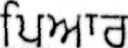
ਪਿਆਰ
